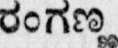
ರಂಗಣ್ಣ
